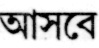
আসবে
